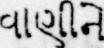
વાણીને
